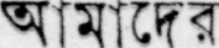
আমাদের
